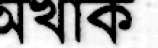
অখাক
